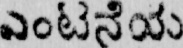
ಎಂಟನೆಯ
